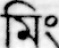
মিং
